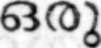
ഒരു
